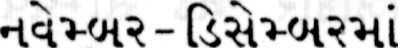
નવેમ્બર-ડિસેમ્બરમાં
